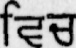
ਵਿਚ
